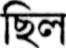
ছিল
